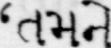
'તમને
